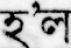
হ'ল
